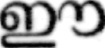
ഈ
